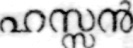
ഹസ്സന്‍
